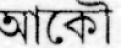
আকৌ
